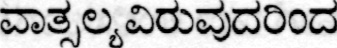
ವಾತ್ಸಲ್ಯವಿರುವುದರಿಂದ
